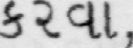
કરવા,
